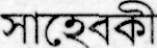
সাহেবকী
